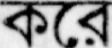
করে
